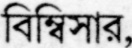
বিম্বিসার,
